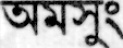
অমসুং
